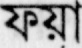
ফয়া
